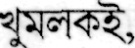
খুমলকই,
